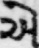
એ
